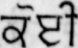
ਕੋਈ
